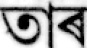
তাৰ
